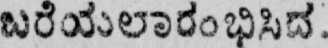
ಬರೆಯಲಾರಂಭಿಸಿದ.
